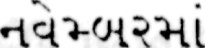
નવેમ્બરમાં
